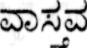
ವಾಸ್ತವ
